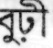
বুঢ়ী
